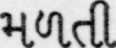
મળતી
